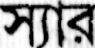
স্যার
